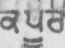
ਕਪੂਰ
